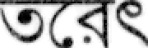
তরেৎ
